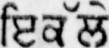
ਇਕੱਲੇ
